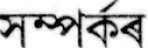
সম্পর্কৰ
